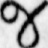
જ
